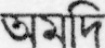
অমদি
